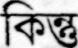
কিন্তু
